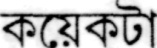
কয়েকটা
